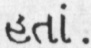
હતાં.
